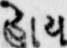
હોય
